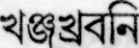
খঞ্জখ্রবনি
